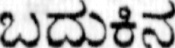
ಬದುಕಿನ
